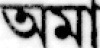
অমা
